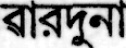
ৱারদুনা
